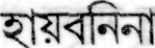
হায়বনিনা
